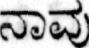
ನಾವು
